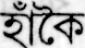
হাঁকৈ
